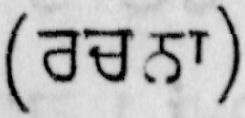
(ਰਚਨਾ)
